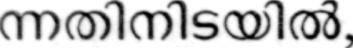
ന്നതിനിടയില്‍,
